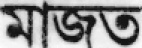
মাজত
